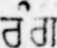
ਰੰਗ
